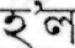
হ'ল
